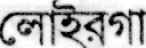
লোইরগা
